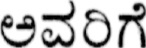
ಅವರಿಗೆ
